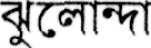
ঝুলোন্দা
